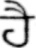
ਹੈ
